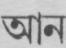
আন
